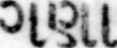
ગણા
